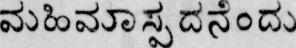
ಮಹಿಮಾಸ್ಪದನೆಂದು
